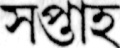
সপ্তাহ
